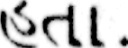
હતા.
